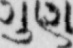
ગુણ
